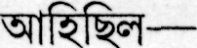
আহিছিল-
